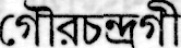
গৌরচন্দ্রগী
